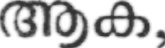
ആക,
